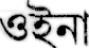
ওইনা
